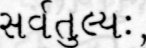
સર્વતુલ્યઃ,
